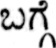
ಬಗ್ಗೆ
